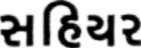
સહિયર
